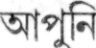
আপুনি
